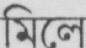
মিলে
